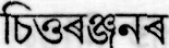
চিত্তৰঞ্জনৰ
